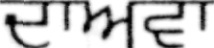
ਦਾਅਵਾ
